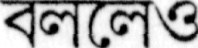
বললেও
